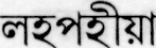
লহপহীয়া
